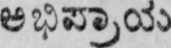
ಅಭಿಪ್ರಾಯ
